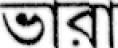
ভারা
